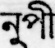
নুপী
